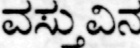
ವಸ್ತುವಿನ
